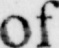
of
